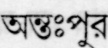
অন্তঃপুর
